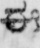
ಈ
